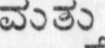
ಮತ್ತು
